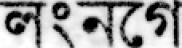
লংনগে
